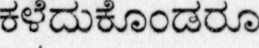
ಕಳೆದುಕೊಂಡರೂ
